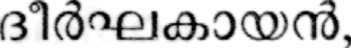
ദീര്‍ഘകായന്‍,
